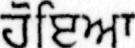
ਹੋਇਆ
